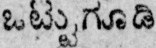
ಒಟ್ಟುಗೂಡಿ
